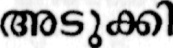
അടുക്കി
